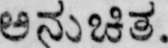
ಅನುಚಿತ.
